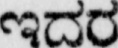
ಇದರ
